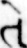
તે
